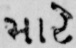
માટે
